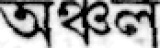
অঞ্চল
